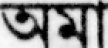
অমা
